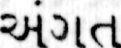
અંગત
